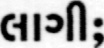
લાગી;
